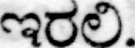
ಇರಲಿ.
